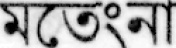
মতেংনা
